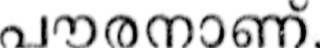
പൌരനാണ്.
